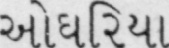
ઓઘરિયા
